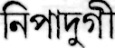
নিপাদুগী
